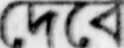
দেবে
